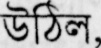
উঠিল,
